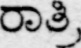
ರಾತ್ರಿ
